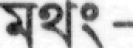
মথং-
